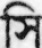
সি
